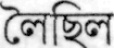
লৈছিল
